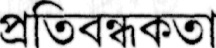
প্রতিবন্ধকতা
